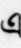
এ
